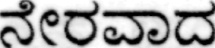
ನೇರವಾದ
